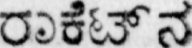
ರಾಕೆಟ್‌ನ
